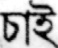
চাই
